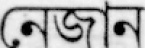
নেজান
